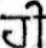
ਹੀ
